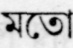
মতো
